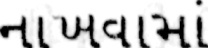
નાખવામાં
